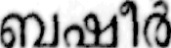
ബഷീര്‍
